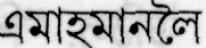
এমাহমানলৈ
